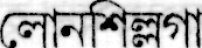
লোনশিল্লগা
